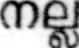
നല്ല
